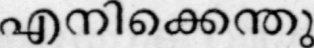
എനിക്കെന്തു
